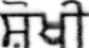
ਸ਼ੋਖੀ
